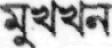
মুখখন
